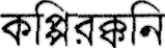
কপ্পিরক্কনি
